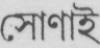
সোণাই
